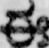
ಈ
